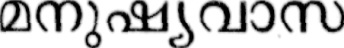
മനുഷ്യവാസ
